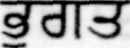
ਭੁਗਤ
